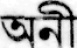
অনী
